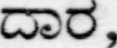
ದಾರ,
